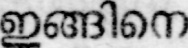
ഇങ്ങിനെ
